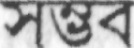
সম্ভব
